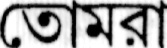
তোমরা
